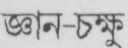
জ্ঞান-চক্ষু
